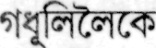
গধূলিলৈকে
